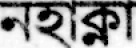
নহাক্না
